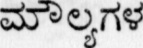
ಮೌಲ್ಯಗಳ
